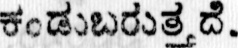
ಕಂಡುಬರುತ್ತದೆ.
